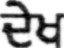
ਦੇਖ
